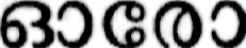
ഓരോ
